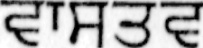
ਵਾਸਤਵ
